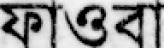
ফাওবা
